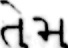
તેમ
